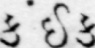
કંઈક
